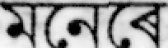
মনেৰে
